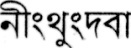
নীংথুংদবা
